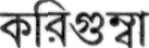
করিগুম্বা
